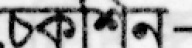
চেকশিন
